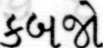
કબજો
